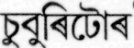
চুবুৰিটোৰ
